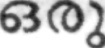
ഒരു
